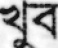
খুব
